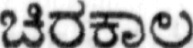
ಚಿರಕಾಲ
